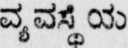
ವ್ಯವಸ್ಥೆಯ
